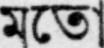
মতো
